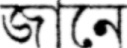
জানে
